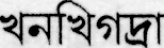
খনখিগদ্রা
